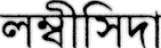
লম্বীসিদা
